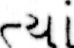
ત્યાં
